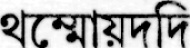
থম্মোয়দদি
